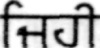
ਜਿਹੀ
